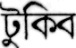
টুকিব
